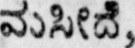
ಮಸೀದೆ,
